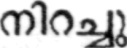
നിറച്ചു
